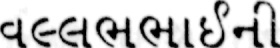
વલ્લભભાઈની
